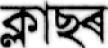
ক্লাছৰ
